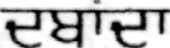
ਦਬਾਂਦਾ
